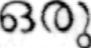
ഒരു
